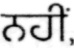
ਨਹੀਂ,
